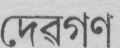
দেৱগণ
